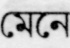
মেনে
